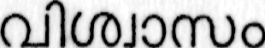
വിശ്വാസം
